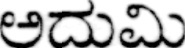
ಅದುಮಿ
